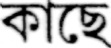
কাছে
